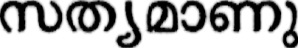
സത്യമാണു
